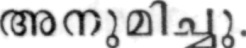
അനുമിച്ചു.
